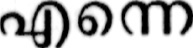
എന്നെ
